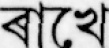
ৰাখে
